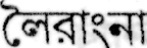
লৈরাংনা
